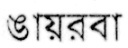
ঙায়রবা
